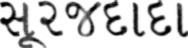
સૂરજદાદા
